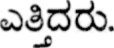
ಎತ್ತಿದರು.
